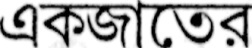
একজাতের
